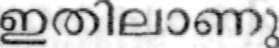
ഇതിലാണു
